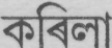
কৰিলা
